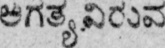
ಅಗತ್ಯವಿರುವ
